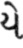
યે
